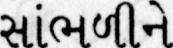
સાંભળીને
